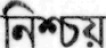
নিশ্চয়
